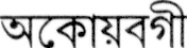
অকোয়বগী
